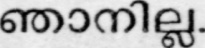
ഞാനില്ല.
